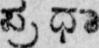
ಪ್ರಧಾ
